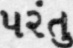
પરંતુ
